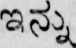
ಇನ್ನು
